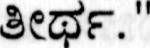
ತೀರ್ಥ.”
